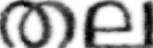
തല
